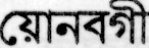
য়োনবগী
